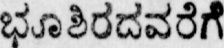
ಭೂಶಿರದವರೆಗೆ
